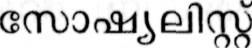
സോഷ്യലിസ്റ്റ്
